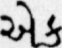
એક
